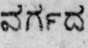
ವರ್ಗದ
